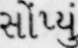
સોંપ્યું
